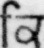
ਕਿ
